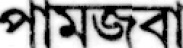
পামজবা
